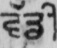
ਵੱਡੀ
